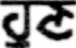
ਹੁਣ
